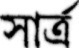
সার্ত্র
